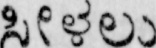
ಸೀಳಲು
